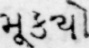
મૂક્યો
